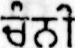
ਚੰਨੀ
